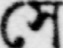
সে
